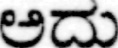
ಅದು
